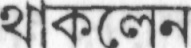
থাকলেন
